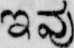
ಇವು
